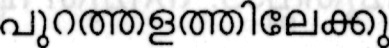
പുറത്തളത്തിലേക്കു
